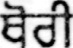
ਥੋਰੀ
